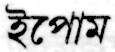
ইপোম
